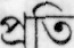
প্রতি
